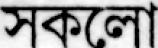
সকলো
